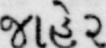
જાહેર
